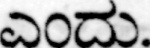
ಎಂದು.
